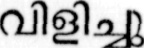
വിളിച്ചു
